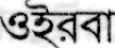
ওইরবা
